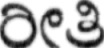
ರೀತಿ
